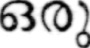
ഒരു
